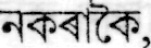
নকৰাকৈ,
